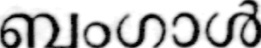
ബംഗാള്‍
